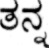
ತನ್ನ
